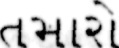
તમારો
